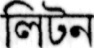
লিটন
